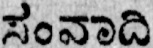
ಸಂವಾದಿ
